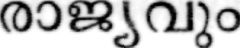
രാജ്യവും
